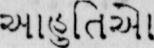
આહુતિઓ
